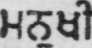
ਮਨੁਖੀ
